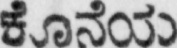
ಕೊನೆಯ
